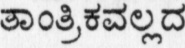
ತಾಂತ್ರಿಕವಲ್ಲದ
